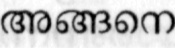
അങ്ങനെ
